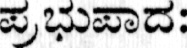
ಪ್ರಭುಪಾದ:
